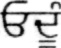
ਓਦੂੰ
